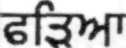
ਫੜਿਆ
